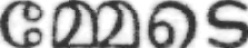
മ്മേടെ
